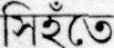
সিহঁতে
